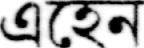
এহেন
